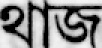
থাজ
